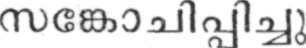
സങ്കോചിപ്പിച്ചു
